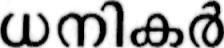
ധനികര്‍
